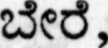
ಬೇರೆ,
